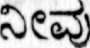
ನೀವು
